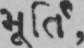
મૂર્તિ,
